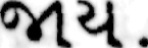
જાય.
